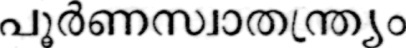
പൂര്‍ണസ്വാതന്ത്ര്യം
